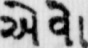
એવો
